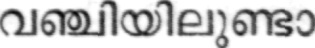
വഞ്ചിയിലുണ്ടാ
